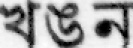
খঙন
